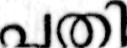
പതി
